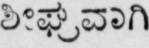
ಶೀಘ್ರವಾಗಿ
